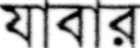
যাবার
